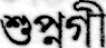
শুপ্নগী
